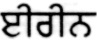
ਈਰੀਨ
